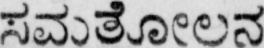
ಸಮತೋಲನ
